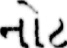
નોટ
